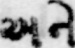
અને
